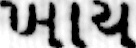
ખાય
